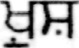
ਖ਼ੁਸ਼
